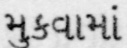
મુકવામાં
